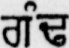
ਗੰਢ
